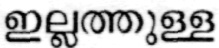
ഇല്ലത്തുള്ള
